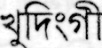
খুদিংগী
